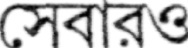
সেবারও
